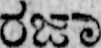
ರಜಾ
